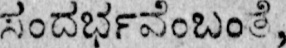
ಸಂದರ್ಭವೆಂಬಂತೆ,
